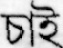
চাই
